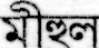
মীহুল
